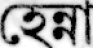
হেন্না
